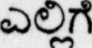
ಎಲ್ಲಿಗೆ
